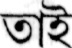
তাই
